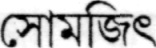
সোমজিৎ
